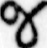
જ
